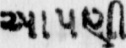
આપણી
